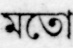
মতো
